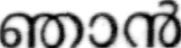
ഞാന്‍
